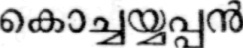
കൊച്ചയ്യപ്പന്‍
